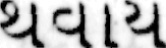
થવાય
